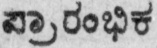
ಪ್ರಾರಂಭಿಕ
